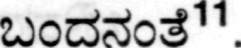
ಬಂದನಂತೆ11
